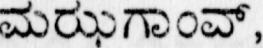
ಮಝಗಾಂವ್,
